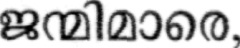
ജന്മിമാരെ,
